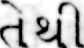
તેથી
